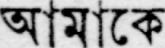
আমাকে
